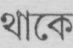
থাকে
